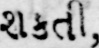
શકતી,
